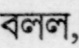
বলল,
